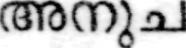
അനുച
